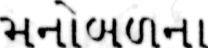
મનોબળના
